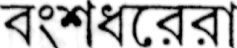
বংশধরেরা
